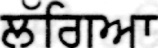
ਲੱਗਿਆ
